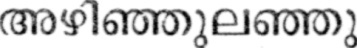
അഴിഞ്ഞുലഞ്ഞു
